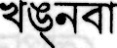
খঙ্নবা
